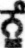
ਨੂੰ
